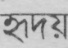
হৃদয়
